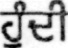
ਹੁੰਦੀ
